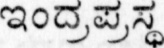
ಇಂದ್ರಪ್ರಸ್ಥ
